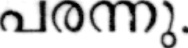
പരന്നു.
